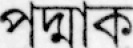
পদ্মাক
